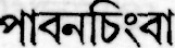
পাবনচিংবা
